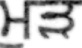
ਮੁੜ
